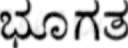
ಭೂಗತ
